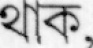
থাক,
